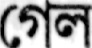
গেল
